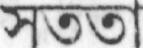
সততা
